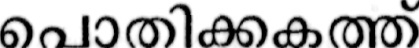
പൊതിക്കകത്ത്
